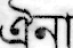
ঐনা
